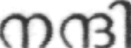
നന്ദി
